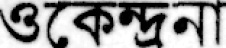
ওকেন্দ্রনা
